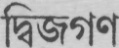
দ্বিজগণ
